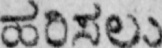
ಹರಿಸಲು
